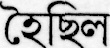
হৈছিল
